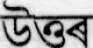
উত্তৰ
